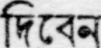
দিবেন
